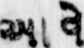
આવે
